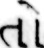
તો
